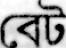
বেট
